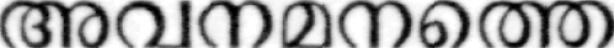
അവനമനത്തെ
